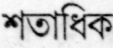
শতাধিক
